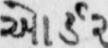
ઓર્ડર
